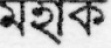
মহাক
